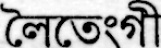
লৈতেংগী
